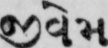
જીવેમ
